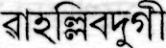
ৱাহল্লিবদুগী
